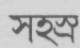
সহস্ৰ
